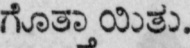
ಗೊತ್ತಾಯಿತು.
